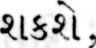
શકશે,
